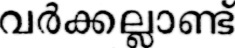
വര്‍ക്കല്ലാണ്ട്
